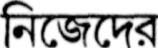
নিজেদের
